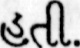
હતી.
